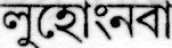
লুহোংনবা
